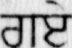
ਗਏ
